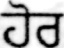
ਹੋਰ
